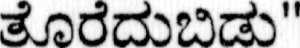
ತೊರೆದುಬಿಡು”
